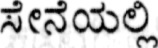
ಸೇನೆಯಲ್ಲಿ
